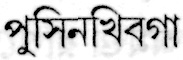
পুসিনখিবগা
